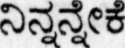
ನಿನ್ನನ್ನೇಕೆ
